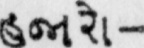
હજારો-
